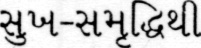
સુખ-સમૃદ્ધિથી
